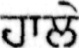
ਹਾਲੇ
